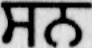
ਸਨ
